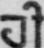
ਹੀ
